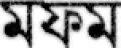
মফম
